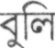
বুলি
